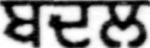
ਬਦਲ
